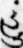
હું
